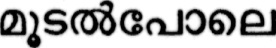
മൂടല്‍പോലെ
